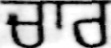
ਚਾਰ
